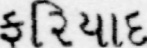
ફરિયાદ
